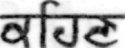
ਕਹਿਣ
